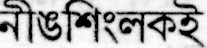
নীঙশিংলকই
